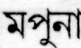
মপুনা
